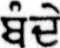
ਬੰਦੇ
